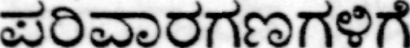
ಪರಿವಾರಗಣಗಳಿಗೆ
